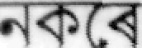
নকৰে
